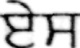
ਏਸ
